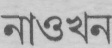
নাওখন
